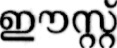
ഈസ്റ്റ്
